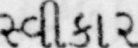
સ્વીકાર
